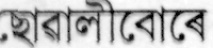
ছোৱালীবোৰে
